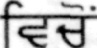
ਵਿਚੋਂ
